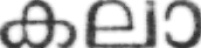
കലാ
